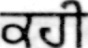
ਕਹੀ
